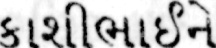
કાશીભાઈને
